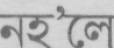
নহ'লে
